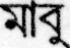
মাবু
